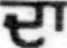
ਦਾ
